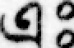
এঃ
